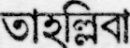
তাহল্লিবা
